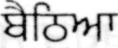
ਬੈਠਿਆ
